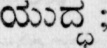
ಯುದ್ಧ;
